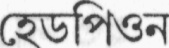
হেডপিওন
